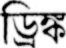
ড্রিঙ্ক
